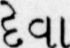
દેવા
